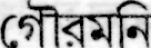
গৌরমনি
